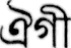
ঐগী
